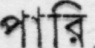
পারি
